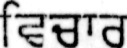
ਵਿਚਾਰ
